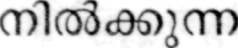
നില്‍ക്കുന്ന
